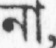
না,
